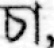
চা,
